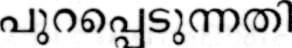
പുറപ്പെടുന്നതി
